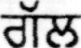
ਗੱਲ
